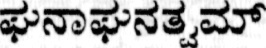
ಘನಾಘನತ್ವಮ್
